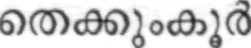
തെക്കുംകൂര്‍
